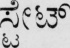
ಸ್ಟೇಟ್
